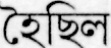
হৈছিল
